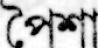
পৈশা
